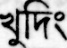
খুদিং
